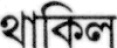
থাকিল
